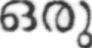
ഒരു
